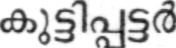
കുട്ടിപ്പട്ടര്‍
